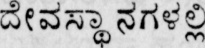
ದೇವಸ್ಥಾನಗಳಲ್ಲಿ
